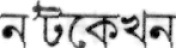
ন'টকেখন
